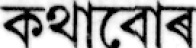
কথাবোৰ
